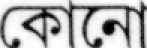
কোনো
